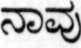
ನಾವು
